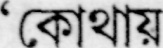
‘কোথায়
